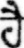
ਹੈ
